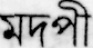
মদপী
